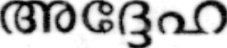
അദ്ദേഹ
